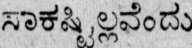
ಸಾಕಷ್ಟಿಲ್ಲವೆಂದು
